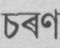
চৰণ
